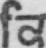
ਕਿ
